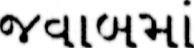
જવાબમાં
